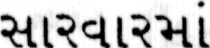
સારવારમાં
